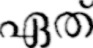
ഏത്
